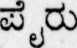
ಪೈರು
